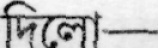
দিলো-
